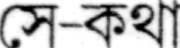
সে-কথা
